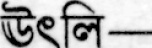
ঊৎলি-
